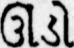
ઊંડો
